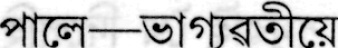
পালে-ভাগ্যৱতীয়ে
